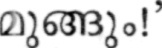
മുങ്ങും!'
